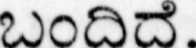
ಬಂದಿದೆ.
